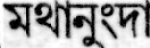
মথানুংদা
